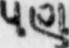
પણ
